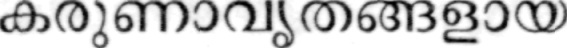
കരുണാവൃതങ്ങളായ
